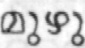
മുഴു
